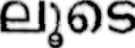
ലൂടെ
